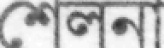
শেলনা
